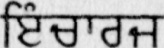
ਇੰਚਾਰਜ
